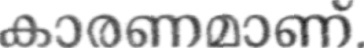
കാരണമാണ്.
